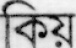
কিয়
